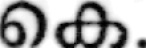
കെ.
